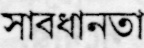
সাবধানতা
